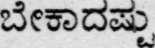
ಬೇಕಾದಷ್ಟು
